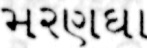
મરણઘા
